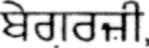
ਬੇਗ਼ਰਜ਼ੀ,
